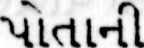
પોતાની
